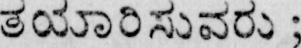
ತಯಾರಿಸುವರು;
